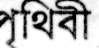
পৃথিবী
